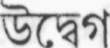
উদ্বেগ
